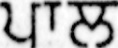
ਪਾਲ
